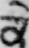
ਕੇ
